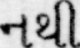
નથી
